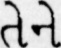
તેને
